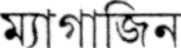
ম্যাগাজিন
